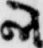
જો
